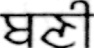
ਬਣੀ
